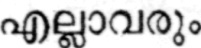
എല്ലാവരും
